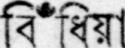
বিঁধিয়া
